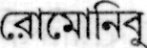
রোমোনিবু
